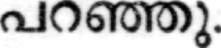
പറഞ്ഞു.
